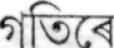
গতিৰে
